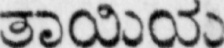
ತಾಯಿಯ
